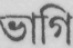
ভাগি
